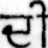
ਦੀ
